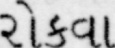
રોકવા
